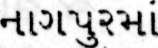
નાગપુરમાં
